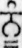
ਨੂੰ
